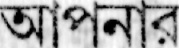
আপনার
